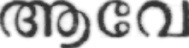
ആവേ
